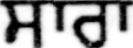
ਸਾਰਾ
